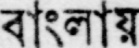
বাংলায়
